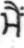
ਮੈਂ
